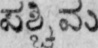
ಪಶ್ಚಿಮ
